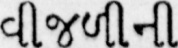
વીજળીની
